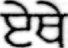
ਏਥੇ
